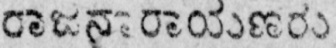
ರಾಜನಾರಾಯಣರು
